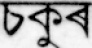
চকুৰ
